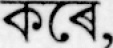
কৰে,
